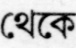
থেকে
